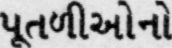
પૂતળીઓનો
